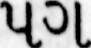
પગ
